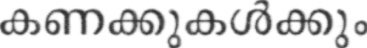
കണക്കുകള്‍ക്കും
